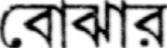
বোঝার
